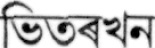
ভিতৰখন
